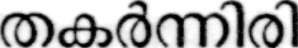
തകര്‍ന്നിരി
